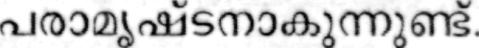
പരാമൃഷ്ടനാകുന്നുണ്ട്.
